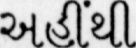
અહીંથી
